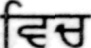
ਵਿਚ
